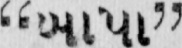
“બાપા”
